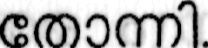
തോന്നി.
